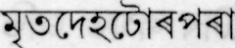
মৃতদেহটোৰপৰা
